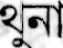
থুনা
